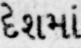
દેશમાં
